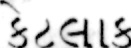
કેટલાક
